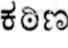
ಕಠಿಣ
